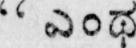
“ಎಂಥ
